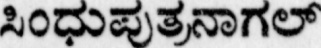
ಸಿಂಧುಪುತ್ರನಾಗಲ್
